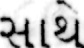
સાથે
